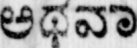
ಅಥವಾ
